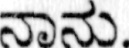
ನಾನು.
